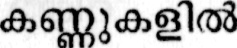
കണ്ണുകളില്‍
